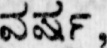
ವರ್ಷ,
